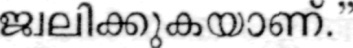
ജ്വലിക്കുകയാണ്.”
